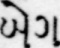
બેગ
